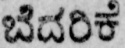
ಬೆದರಿಕೆ
